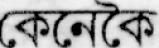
কেনেকৈ
